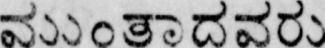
ಮುಂತಾದವರು
